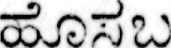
ಹೊಸಬ
